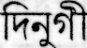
দিনুগী
